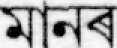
মানৰ
